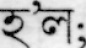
হ'ল;
